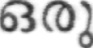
ഒരു
